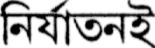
নির্যাতনই
